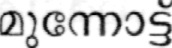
മുന്നോട്ട്
